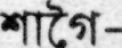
শাগৈ-
